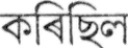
কৰিছিল
